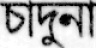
চাদুনা
